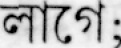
লাগে;
